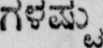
ಗಳಷ್ಟು
